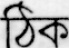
ঠিক
